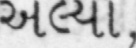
અલ્યા,
